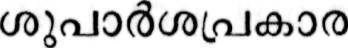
ശുപാര്‍ശപ്രകാര
